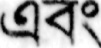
এবং
